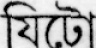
যিটো
